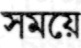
সময়ে
